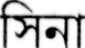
ইসি
